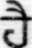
ਹੈ
